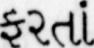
ફરતાં
